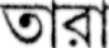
তারা
